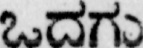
ಒದಗು
